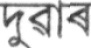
দুৱাৰ
